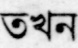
তখন
